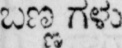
ಬಣ್ಣಗಳು
